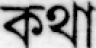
কথা
